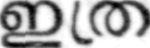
ഇത്ര
